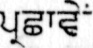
ਪ੍ਰਛਾਵੇਂ
